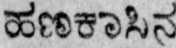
ಹಣಕಾಸಿನ
